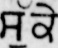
ਸੁੱਕੇ
